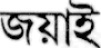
জয়াই
